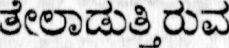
ತೇಲಾಡುತ್ತಿರುವ
